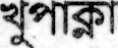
খুপাক্না
